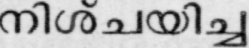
നിശ്ചയിച്ച
